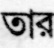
তার
